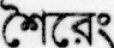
শৈরেং
